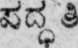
ಪದ್ಧತಿ
